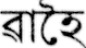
ৱাহৈ
